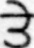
ਤੇ
